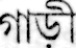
গাড়ী
